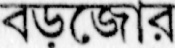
বড়জোর
